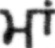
ਮਾਂ
